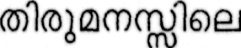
തിരുമനസ്സിലെ
